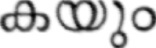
കയും
